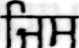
ਜਿਸ
